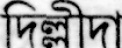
দিল্লীদা
